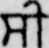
ਸੀ
